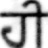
ਹੀ
